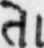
તો
